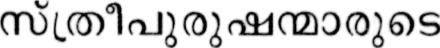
സ്ത്രീപുരുഷന്മാരുടെ
